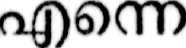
എന്നെ
